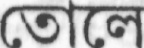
তোলে
